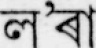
ল'ৰা
